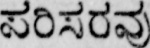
ಪರಿಸರವು
